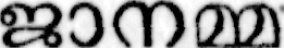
ജാനമ്മ
